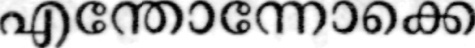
എന്തോന്നോക്കെ
